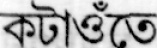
কটাওঁতে
